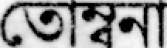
তোম্বনা
